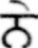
ਨੇ
